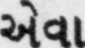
એવા
